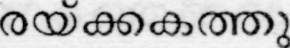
രയ്ക്കകത്തു
